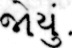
જોયું.
